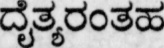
ದೈತ್ಯರಂತಹ
